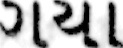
ગયા
